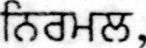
ਨਿਰਮਲ,
